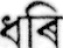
ধৰি
